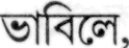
ভাবিলে,
